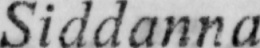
Siddanna
